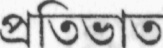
প্রতিভাত
